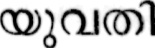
യുവതി
